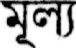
মূল্য
